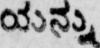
ಯನ್ನು
